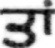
ਤਾਂ
